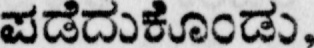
ಪಡೆದುಕೊಂಡು,
